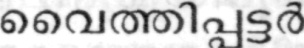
വൈത്തിപ്പട്ടര്‍
